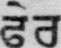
ਫੇਰ
